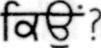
ਕਿਉਂ?
